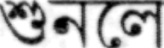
শুনলে
